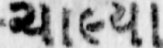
ચાલ્યા
